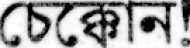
চেক্কোন
